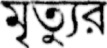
মৃত্যুর
